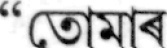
"তোমাৰ
